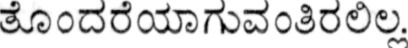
ತೊಂದರೆಯಾಗುವಂತಿರಲಿಲ್ಲ
